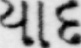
યાદ
